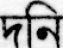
দনি
